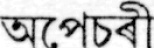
অপেচৰী
